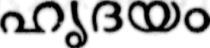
ഹൃദയം
